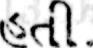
હતી.
